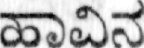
ಹಾವಿನ
